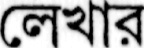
লেখার
